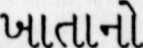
ખાતાનો
